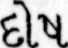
દોષ
